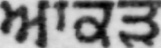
ਆਕੜ
